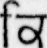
ਕਿ
